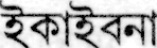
ইকাইবনা
